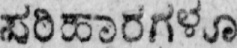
ಪರಿಹಾರಗಳೂ
